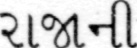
રાજાની
